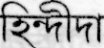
হিন্দীদা
